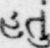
હતું
